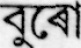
বুৰো
